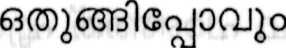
ഒതുങ്ങിപ്പോവും
